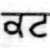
ਕਟ
